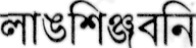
লাঙশিঞ্জবনি
